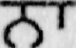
ਨਾ
